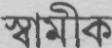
স্বামীক
